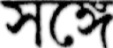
সঙ্গে
